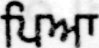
ਪਿਆ
